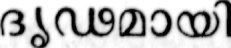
ദൃഢമായി
